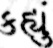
કહ્યું
